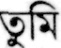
তুমি
